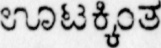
ಊಟಕ್ಕಿಂತ
